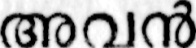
അവന്‍
